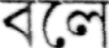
বলে
